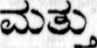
ಮತ್ತು
